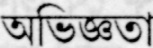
অভিজ্ঞতা
